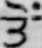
ਤੋਂ
